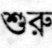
শুরু
